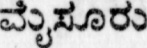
ಮೈಸೂರು
